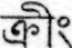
ক্রীং
